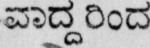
ವಾದ್ದರಿಂದ
